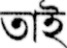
তাই
